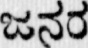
ಜನರ
